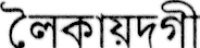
লৈকায়দগী
